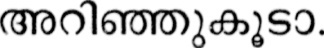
അറിഞ്ഞുകൂടാ.
